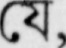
যে,
